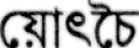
য়োৎচৈ
